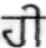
ਹੀ
